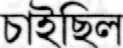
চাইছিল
